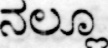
ನಲ್ಲೂ
